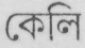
কেলি
